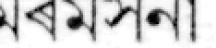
মৰমসনা
